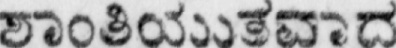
ಶಾಂತಿಯುತವಾದ
